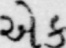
એક
